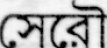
সেরৌ
